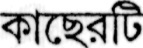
কাছেরটি
